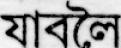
যাবলৈ
